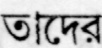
তাদের
